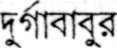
দুর্গাবাবুর
